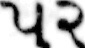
પર
